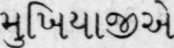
મુખિયાજીએ
